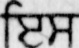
ਇਸ
